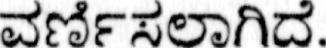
ವರ್ಣಿಸಲಾಗಿದೆ.
